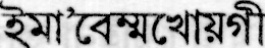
ইমা’বেম্মখোয়গী
